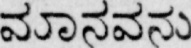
ಮಾನವನು
